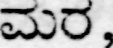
ಮರ,
